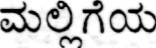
ಮಲ್ಲಿಗೆಯ
